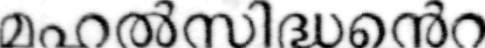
മഹല്‍സിദ്ധന്റെ
